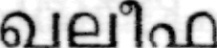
ഖലീഫ
